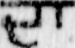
ਦਾ
